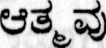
ಆತ್ಮವು
